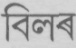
বিলৰ
